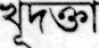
খূদক্তা
